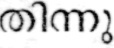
തിന്നു
